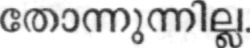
തോന്നുന്നില്ല.
